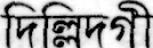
দিল্লিদগী
